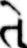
તે
